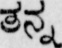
ತನ್ನ
